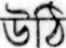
উঠি
